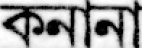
কনানা
